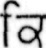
ਕਿ
